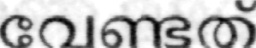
വേണ്ടത്
